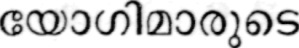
യോഗിമാരുടെ
